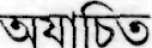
অযাচিত
